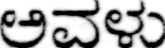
ಅವಳು
